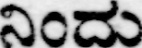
ನಿಂದು
